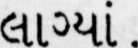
લાગ્યાં.
